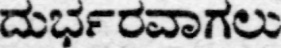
ದುರ್ಭರವಾಗಲು
